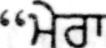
''ਮੇਰਾ
